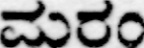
ಮರಂ
